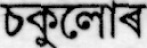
চকুলোৰ
